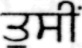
ਤੁਸੀਂ
